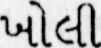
ખોલી
